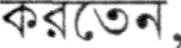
করতেন,
